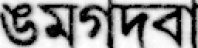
ঙমগদবা
